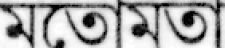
মতোমদা
